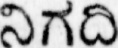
ನಿಗದಿ
